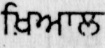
ਖ਼ਿਆਲ
